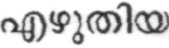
എഴുതിയ
